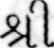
શ્રી
